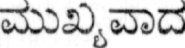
ಮುಖ್ಯವಾದ
